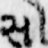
સો
